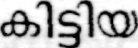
കിട്ടിയ
